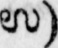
ಉ)
